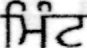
ਮਿੰਟ
